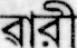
ৱারী
